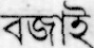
বজাই
